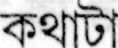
কথাটা
